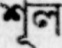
শূল
